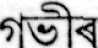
গভীৰ
